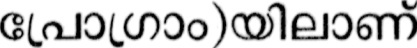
പ്രോഗ്രാം)യിലാണ്
